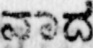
ವಾದ
